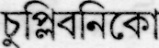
চুপ্লিবনিকো
